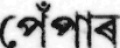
পেঁপাৰ
